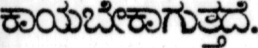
ಕಾಯಬೇಕಾಗುತ್ತದೆ.
